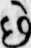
છે
